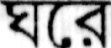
ঘরে
